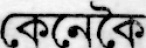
কেনেকৈ
